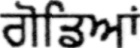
ਗੋਡਿਆਂ
